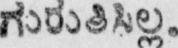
ಗುರುತಿಸಿಲ್ಲ.
